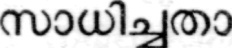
സാധിച്ചതാ
